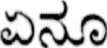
ಏನೂ
